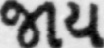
જાય
